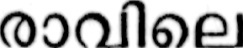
രാവിലെ
